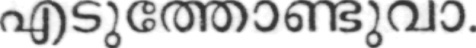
എടുത്തോണ്ടുവാ.
